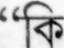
"কি
